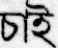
চাই
